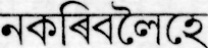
নকৰিবলৈহে
